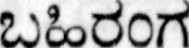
ಬಹಿರಂಗ
